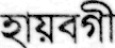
হায়বগী
